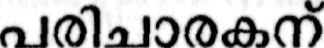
പരിചാരകന്
